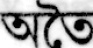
অতৈ
